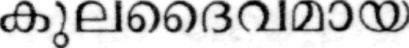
കുലദൈവമായ
